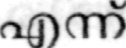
എന്ന്
